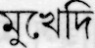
মুখেদি
